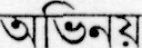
অভিনয়
